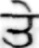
ਤੇ
